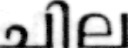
ചില
